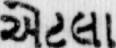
એટલા
